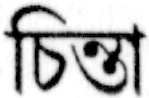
চিন্তা
